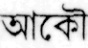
আকৌ
